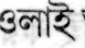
ওলাই
